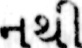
નથી
